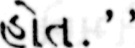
હોત."
